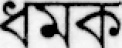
ধমক
